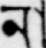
না
